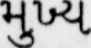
મુખ્ય
